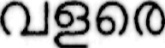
വളരെ
